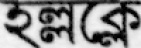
হল্লক্লে
